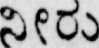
ನೀರು
